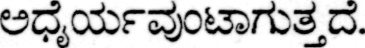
ಅಧೈರ್ಯವುಂತಾಗುತ್ತದೆ.
